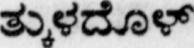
ತ್ಕುಳದೊಳ್
